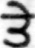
ਤੇ
